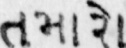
તમારો
